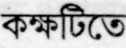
কক্ষটিতে
